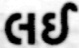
લઈ
